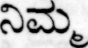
ನಿಮ್ಮ
